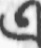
এ
